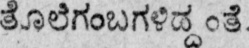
ತೊಲೆಗಂಬಗಳಿದ್ದಂತೆ.
